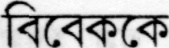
বিবেককে
